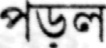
পড়ল
